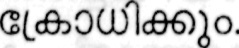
ക്രോധിക്കും.
